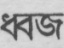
ধ্বজ
